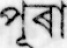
পূৰা
